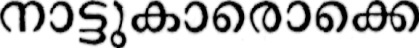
നാട്ടുകാരൊക്കെ
